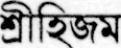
শ্রীহিজম
